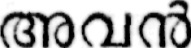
അവന്‍
